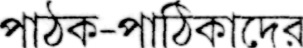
পাঠক-পাঠিকাদের
